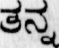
ತನ್ನ
